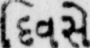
દિવસે
